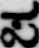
ಪ
